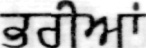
ਭਰੀਆਂ
